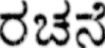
ರಚನೆ
